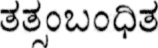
ತತ್ಸಂಬಂಧಿತ
